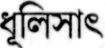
ধূলিসাৎ
